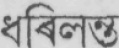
ধৰিলন্ত
